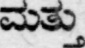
ಮತ್ತು
